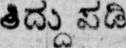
ತಿದ್ದುಪಡಿ
